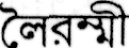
লৈরম্মী
